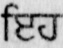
ਇਹ
